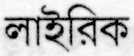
লাইরিক
